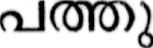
പത്തു
